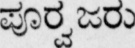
ಪೂರ್‍ವಜರು
